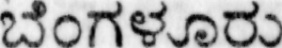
ಬೆಂಗಳೂರು
